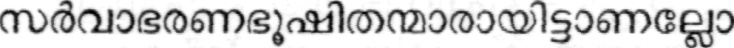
സര്‍വാഭരണഭൂഷിതന്മാരായിട്ടാണല്ലോ
